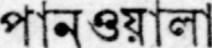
পানওয়ালা
